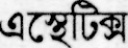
এস্থেটিক্স
